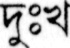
দুঃখ
